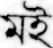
মই
